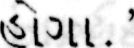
હોગા.'
